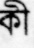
কী
